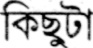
কিছুটা
